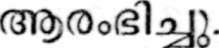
ആരംഭിച്ചു.
